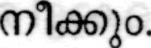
നീക്കും.
